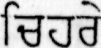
ਚਿਹਰੇ
